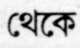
থেকে
